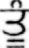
ਤੂੰ
